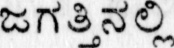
ಜಗತ್ತಿನಲ್ಲಿ
